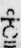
ਨੂੰ
